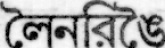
লৈনরিঙৈ
